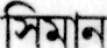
সিমান
